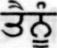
ਤੈਨੂੰ
